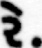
રે.
